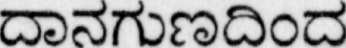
ದಾನಗುಣದಿಂದ
